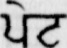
ਪੇਟ
